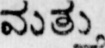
ಮತ್ತು
